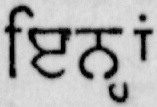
ਇਨ੍ਹਾਂ
